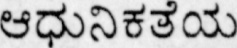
ಆಧುನಿಕತೆಯ
